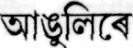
আঙুলিৰে
